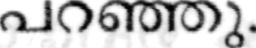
പറഞ്ഞു.
